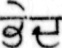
ਭੇਦ
